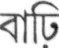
বাঢ়ি
